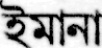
ইমানা
